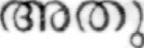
അതു
